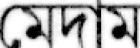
মেদাম
